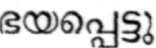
ഭയപ്പെട്ടു
